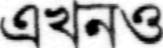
এখনও
